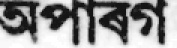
অপাৰগ
